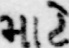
માટે
